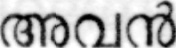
അവന്‍
